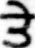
ਤੇ
